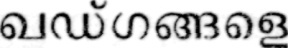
ഖഡ്ഗങ്ങളെ
